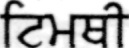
ਟਿਮਥੀ
